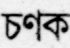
চণক
